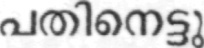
പതിനെട്ടു
